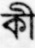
কী
